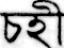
চহী
